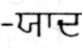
-ਯਾਦ
